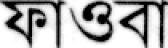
ফাওবা
